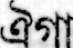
ঐগা
